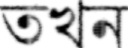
তখন
